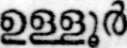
ഉള്ളൂര്‍
